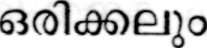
ഒരിക്കലും
